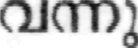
വന്നു
